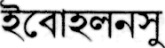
ইবোহলনসু
